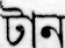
টান
